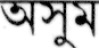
অসুম
